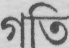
গতি
